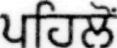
ਪਹਿਲੋਂ
